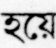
হয়ে
